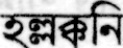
হল্লক্কনি
